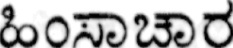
ಹಿಂಸಾಚಾರ
